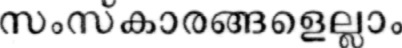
സംസ്കാരങ്ങളെല്ലാം
